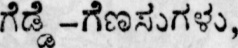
ಗೆಡ್ಡೆ-ಗೆಣಸುಗಳು,
